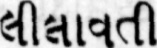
લીલાવતી
